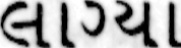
લાગ્યા
